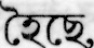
হৈছে,
